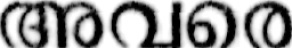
അവരെ
